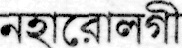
নহারোলগী
